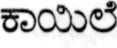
ಕಾಯಿಲೆ
